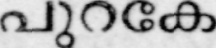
പുറകേ
